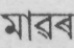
মাৱৰ
